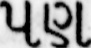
પણ
